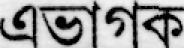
এভাগক
